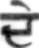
ਦੇ
